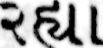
રહ્યા
